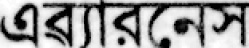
এৱ্যারনেস
